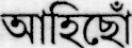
আহিছোঁ
